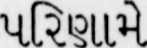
પરિણામે
